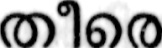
തീരെ
